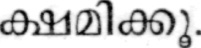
ക്ഷമിക്കൂ.
